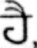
ਹੈ,
